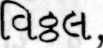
વિઠ્ઠલ,
